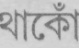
থাকোঁ
